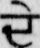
ਦੇ
